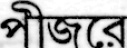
পীজরে
